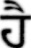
ਹੈ
